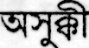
অসুক্কী
